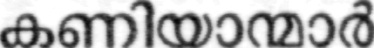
കണിയാന്മാര്‍
